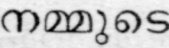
നമ്മുടെ
